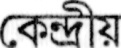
কেন্দ্রীয়
